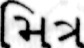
મિત્ર
